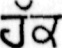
ਹੱਕ
